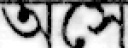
অসে
